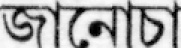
জানোচা
